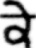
ਕੇ
